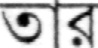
তার
